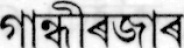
গান্ধীৰজাৰ
